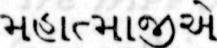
મહાત્માજીએ
